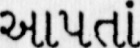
આપતાં
